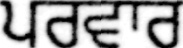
ਪਰਵਾਰ
